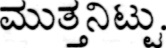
ಮುತ್ತನಿಟ್ಟು.
